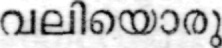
വലിയൊരു
